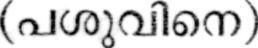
(പശുവിനെ)
